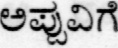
ಅಪ್ಪುವಿಗೆ
